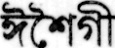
ঈশৈগী
